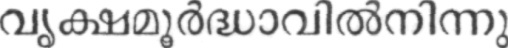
വൃക്ഷമൂര്‍ദ്ധാവില്‍നിന്നു
